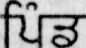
ਪਿੰਡ
